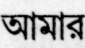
আমার
